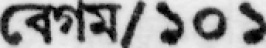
বেগম/১০১
